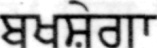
ਬਖਸ਼ੇਗਾ
